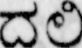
ದಲಿ
